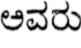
ಅವರು
